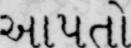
આપતો
